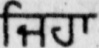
ਜਿਹਾ
